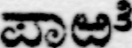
ಪಾಱೆ
